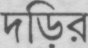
দড়ির
